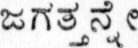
ಜಗತ್ತನ್ನೇ
